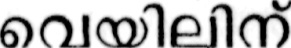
വെയിലിന്
